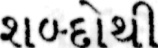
શબ્દોથી
